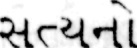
સત્યનો
